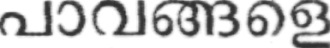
പാവങ്ങളെ
